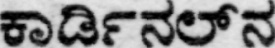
ಕಾರ್ಡಿನಲ್‌ನ
